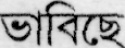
ভাবিছে
